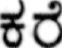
ಕರೆ
